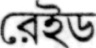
রেইড
